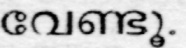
വേണ്ടൂ.
